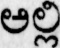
ಅಲ್ಲಿ
